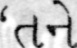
'તને
